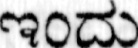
ಇಂದು
